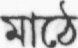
মাঠে
